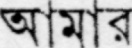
আমার
